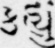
કહ્યું
